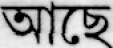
আছে
